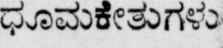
ಧೂಮಕೇತುಗಳು
